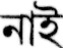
নাই
